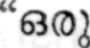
“ഒരു
